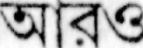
আরও
